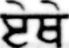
ਏਥੇ
